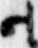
ન
